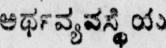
ಅರ್ಥವ್ಯವಸ್ಥೆಯ
